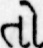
તો
